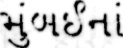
મુંબઈનાં
